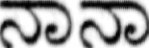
ನಾನಾ
